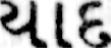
યાદ
